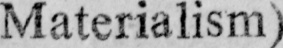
Materialism)
